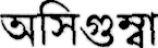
অসিগুম্বা
